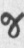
જ
